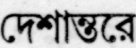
দেশান্তরে
